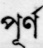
পূর্ণ
